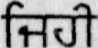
ਜਿਹੀ
